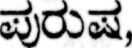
ಪುರುಷ,
